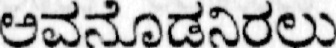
ಅವನೊಡನಿರಲು
